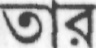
তার
